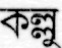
কল্লু
